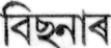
বিছনাৰ
